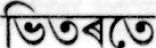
ভিতৰতে
